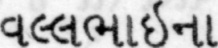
વલ્લભભાઈના
